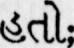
હતો;
